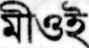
মীওই
